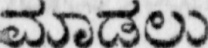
ಮಾಡಲು
